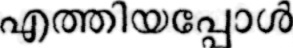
എത്തിയപ്പോള്‍
